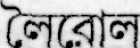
লৈরোল
